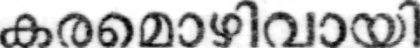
കരമൊഴിവായി
